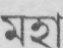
মহা
